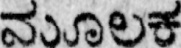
ಮೂಲಕ
